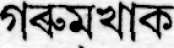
গৰুমখাক
